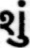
શું
